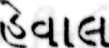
હેવાલ
